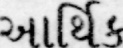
આર્થિક
